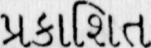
પ્રકાશિત
